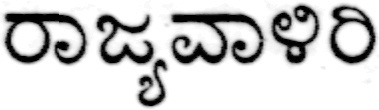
ರಾಜ್ಯವಾಳಿರಿ
